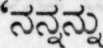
‘ನನ್ನನ್ನು
